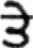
ਤੇ
